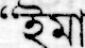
“ইমা
